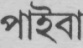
পাইবা
